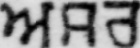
ਅਸਰ
